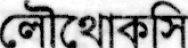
লৌথোকসি
